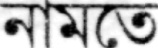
নামতে
